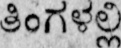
ತಿಂಗಳಲ್ಲಿ
